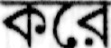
করে
